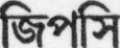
জিপসি
